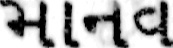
માનવ
